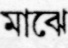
মাঝে
